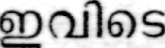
ഇവിടെ
